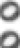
ঃ
